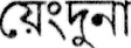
য়েংদুনা
